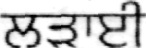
ਲੜਾਈ
